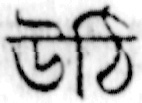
উঠি
